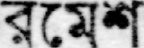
রমেশ
